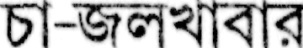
চা-জলখাবার
